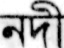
নদী
